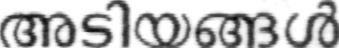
അടിയങ്ങള്‍
